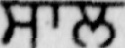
ਸਾਲ
